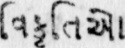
વિકૃતિઓ
